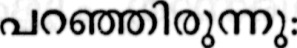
പറഞ്ഞിരുന്നു:
